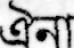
ঐনা
